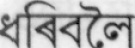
ধৰিবলৈ
